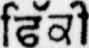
ਫਿੱਕੀ
